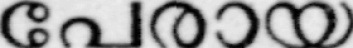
പേരായ
